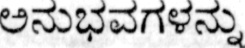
ಅನುಭವಗಳನ್ನು
